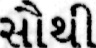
સૌથી
